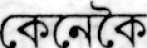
কেনেকৈ
